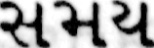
સમય
